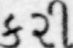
કરી
